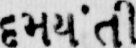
દમયંતી
